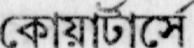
কোয়ার্টার্সে
